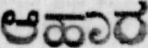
ಆಹಾರ
